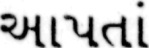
આપતાં
